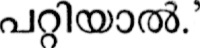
പറ്റിയാല്‍.'
